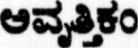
ಅವೃತ್ತಿಕಂ
